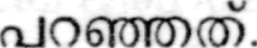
പറഞ്ഞത്.
